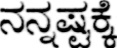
ನನ್ನಷ್ಟಕ್ಕೆ
